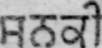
ਸਨਕੀ
